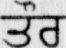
ਤੌਰ
